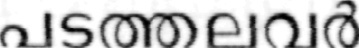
പടത്തലവര്‍
